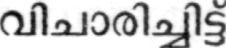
വിചാരിച്ചിട്ട്
